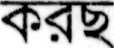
করছ
